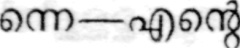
ന്നെ-എന്റെ
